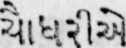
ચૌધરીએ
